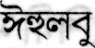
ঈহুলবু
